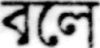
বলে
